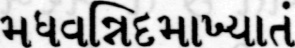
મધવન્નિદમાખ્યાતં
